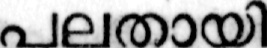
പലതായി
